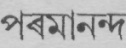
পৰমানন্দ
